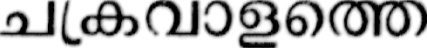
ചക്രവാളത്തെ
